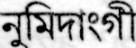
নুমিদাংগী
